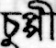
চুপ্পী
